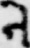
ને
